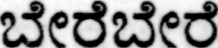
ಬೇರೆಬೇರೆ
